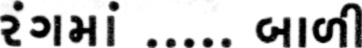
રંગમાં........બાળી
